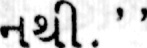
નથી."
